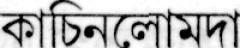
কাচিনলোমদা
